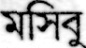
মসিবু
